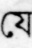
যে
